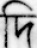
দি
